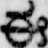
ಈ
